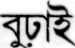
বুঢ়াই
